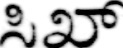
ಸಿಖ್
